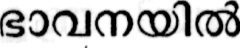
ഭാവനയില്‍
